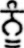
ਨੂੰ
